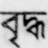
বৃদ্ধ
